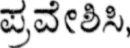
ಪ್ರವೇಶಿಸಿ,
